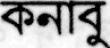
কনাবু
